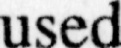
used
